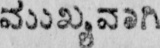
ಮುಖ್ಯವಾಗಿ
